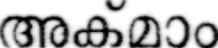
അക്മാം
